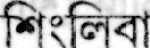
শিংলিবা
